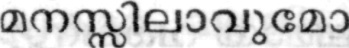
മനസ്സിലാവുമോ
